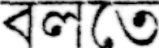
বলতে
